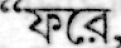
“ফরে,
